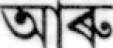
আৰু
